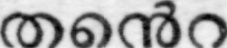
തന്റെ
